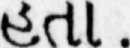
હતા.
